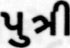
પુત્રી
